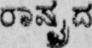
ರಾಷ್ಟ್ರದ
